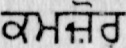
ਕਮਜ਼ੋਰ
